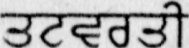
ਤਟਵਰਤੀ
